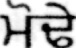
ਮੋਢੇ
